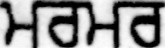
ਮਰਮਰ
